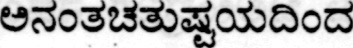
ಅನಂತಚತುಷ್ಟಯದಿಂದ
